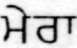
ਮੇਰਾ
